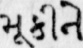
મૂકીને
